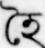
হৈ
